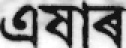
এষাৰ
